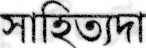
সাহিত্যদা
